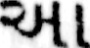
આ
